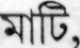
মাটি,
